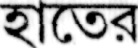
হাতের
